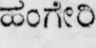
ಹಂಗೇರಿ
